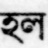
হল
